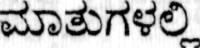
ಮಾತುಗಳಲ್ಲಿ
